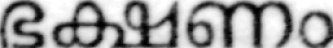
ഭക്ഷണം
